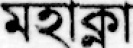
মহাক্না
